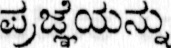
ಪ್ರಜ್ಞೆಯನ್ನು
